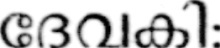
ദേവകി:
